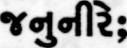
જનુનીરે;
